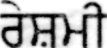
ਰੇਸ਼ਮੀ
